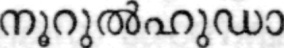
നൂറുല്‍ഹുഡാ
